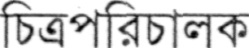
চিত্রপরিচালক
